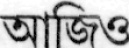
আজিও
